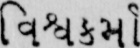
વિશ્વકર્મા
